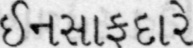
ઈનસાફદારે
